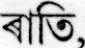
ৰাতি,
